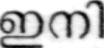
ഇനി
